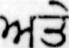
ਅਤੇ
